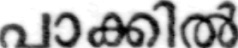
പാക്കില്‍
